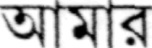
আমার
